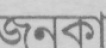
জনকা
